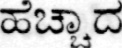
ಹೆಚ್ಚಾದ
